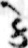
કે
